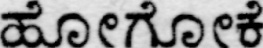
ಹೋಗೋಕೆ
